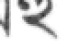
বহু
